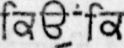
ਕਿਉਂਕਿ
